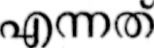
എന്നത്
